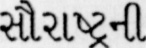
સૌરાષ્ટ્રની
